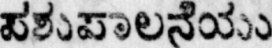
ಪಶುಪಾಲನೆಯು
